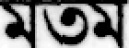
মতম
